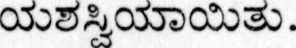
ಯಶಸ್ವಿಯಾಯಿತು.
